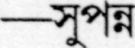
–সুপন্ন
